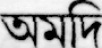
অমদি
